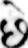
છે
